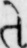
તે
